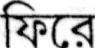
ফিরে
